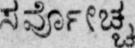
ಸರ್ವೋಚ್ಚ
